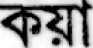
কয়া
